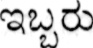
ಇಬ್ಬರು
